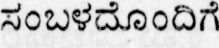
ಸಂಬಳದೊಂದಿಗೆ
